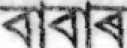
বাবাৰ
